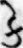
કે
